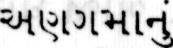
અણગમાનું
